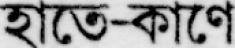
হাতে-কাণে
